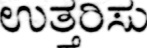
ಉತ್ತರಿಸು
